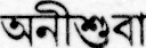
অনীশুবা
